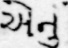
એનું
